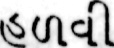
હળવી
